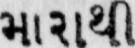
મારાથી
